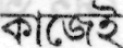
কাজেই
